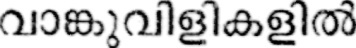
വാങ്കുവിളികളില്‍
